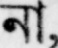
না,
